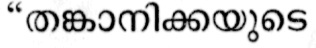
“തങ്കാനിക്കയുടെ
